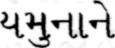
યમુનાને
